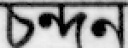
চন্দন
